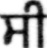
ਸੀ
